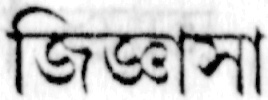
জিজ্ঞাসা
